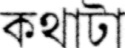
কথাটা
